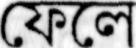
ফেলে
